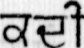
ਕਦੀ
